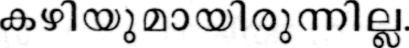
കഴിയുമായിരുന്നില്ല.
